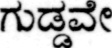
ಗುಡ್ಡವೇ
